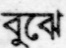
বুঝে
